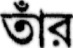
তাঁর
